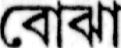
বোঝা
